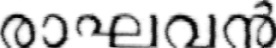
രാഘവന്‍
